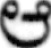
ಆ
